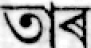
তাৰ
